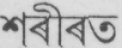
শৰীৰত
